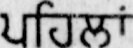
ਪਹਿਲਾਂ
